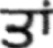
ਤਾਂ
